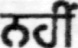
ਨਹੀਂ
